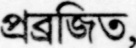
প্রব্রজিত,
